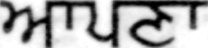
ਆਪਣਾ
